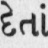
દેતાં
